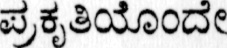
ಪ್ರಕೃತಿಯೊಂದೇ
